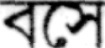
বসে
